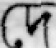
দে
